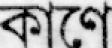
কাণে
